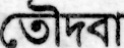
তৌদবা
